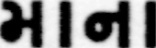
માના
